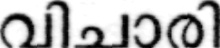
വിചാരി
